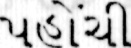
પહોંચી
